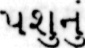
પશુનું
